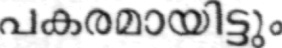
പകരമായിട്ടും
